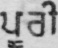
ਪੂਰੀ
